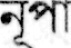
নূপা
